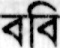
ববি
